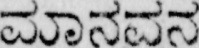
ಮಾನವನ
